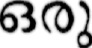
ഒരു
